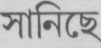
সানিছে
